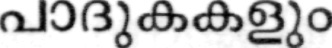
പാദുകകളും
